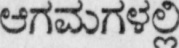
ಆಗಮಗಳಲ್ಲಿ
